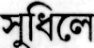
সুধিলে
